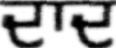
ਦਾਦ
